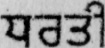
ਧਰਤੀ
